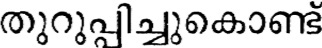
തുറുപ്പിച്ചുകൊണ്ട്
